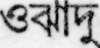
ওঝাদু
